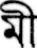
মী
